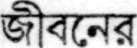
জীবনের
